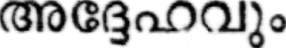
അദ്ദേഹവും
